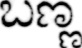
ಬಣ್ಣ
